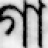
গা
